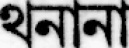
থনানা
